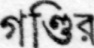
গণ্ডির
